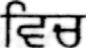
ਵਿਚ
